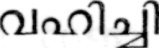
വഹിച്ചി
